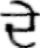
ਦੇ
